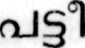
പട്ടീ
